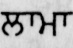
ਲਾਮਾ
